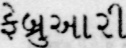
ફેબ્રુઆરી
